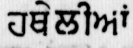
ਹਥੇਲੀਆਂ
